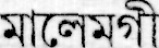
মালেমগী
